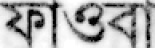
ফাওবা
